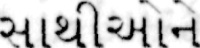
સાથીઓને
